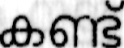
കണ്ട്
